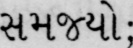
સમજ્યો;
